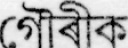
গৌৰীক
